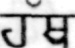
ਹੱਥ
